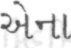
એના
